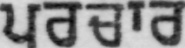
ਪਰਚਾਰ
